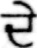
ਦੇ
